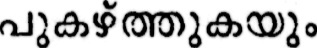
പുകഴ്ത്തുകയും
